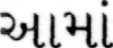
આમાં
